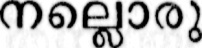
നല്ലൊരു
